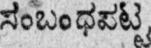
ಸಂಬಂಧಪಟ್ಟ
